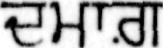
ਦਮਾਗ਼
